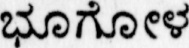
ಭೂಗೋಳ
